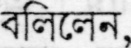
বলিলেন,
